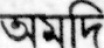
অমদি
